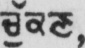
ਚੁੱਕਣ,
